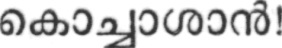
കൊച്ചാശാന്‍!
